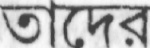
তাদের
